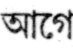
আগে
